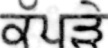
ਕੱਪੜੇ
